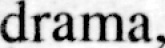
drama,
